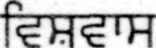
ਵਿਸ਼ਵਾਸ
